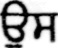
ਉਸ
